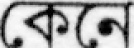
কেনে
